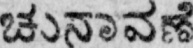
ಚುನಾವಣೆ
